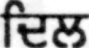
ਦਿਲ
